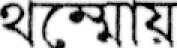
থম্মোয়
